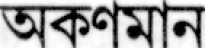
অকণমান
